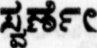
ಸ್ವರ್ಣೇ
